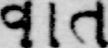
વાત
